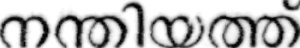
നന്തിയത്ത്
